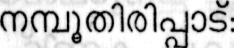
നമ്പൂതിരിപ്പാട്:
